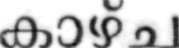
കാഴ്ച
